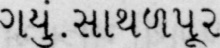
ગયું.સાથળપૂર
